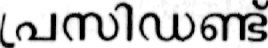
പ്രസിഡണ്ട്
